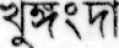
খুঙ্গংদা
